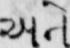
અને
